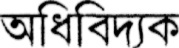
অধিবিদ্যক
